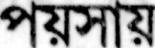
পয়সায়
